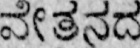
ವೇತನದ
